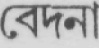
বেদনা
